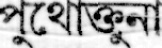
পুথোক্তুনা
